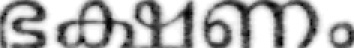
ഭക്ഷണം
